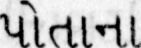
પોતાના
